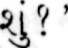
શું?'
